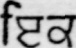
ਇਕ
